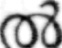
ല്‍
